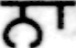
ਨਾ
